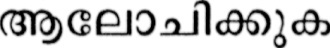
ആലോചിക്കുക
